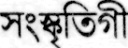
সংস্কৃতিগী
